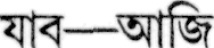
যাব-আজি
